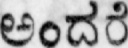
ಅಂದರೆ
